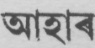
আহাৰ
